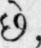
છે,
